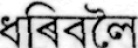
ধৰিবলৈ
